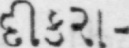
દીકરા-
